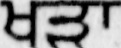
ਖੜਾ
